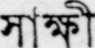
সাক্ষী
